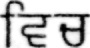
ਵਿਚ
